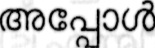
അപ്പോള്‍
